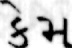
કેમ
